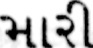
મારી
